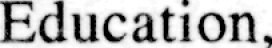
Education,
